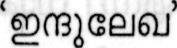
'ഇന്ദുലേഖ'
